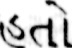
હતો
